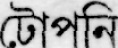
টোপনি
